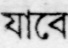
যাবে
